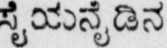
ಸೈಯನೈಡಿನ
